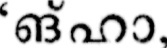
‘ങ്ഹാ,
